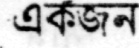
একজন
